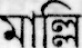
মাল্লি
